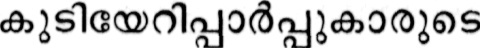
കുടിയേറിപ്പാര്‍പ്പുകാരുടെ
